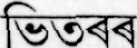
ভিতৰৰ
